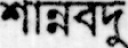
শান্নবদু
